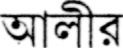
আলীর
